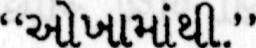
"ઓખામાંથી."
